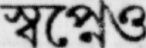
স্বপ্নেও
